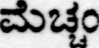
ಮೆಚ್ಚಂ
